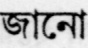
জানো
